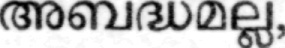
അബദ്ധമല്ല,
